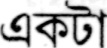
একটা
